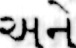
અને
